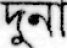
দুনা
